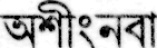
অশীংনবা
